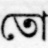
তো
